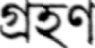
গ্রহণ
